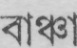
বাঞ্চা
